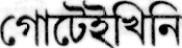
গোটেইখিনি
